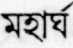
মহার্ঘ
